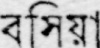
বসিয়া
